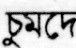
চুমদে
